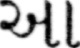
આ
